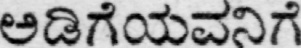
ಅಡಿಗೆಯವನಿಗೆ
